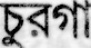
চুরগা
